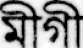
মীগী
